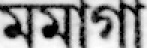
মমাগা
